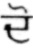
ਦੋ
